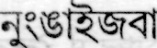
নুংঙাইজবা
